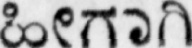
ಹೀಗಾಗಿ
